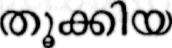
തൂക്കിയ
